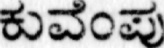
ಕುವೆಂಪು
